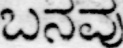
ಬನವು
